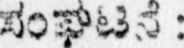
ಸಂಘಟನೆ:
